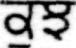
ਕੁਝ
